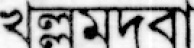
খল্লমদবা
